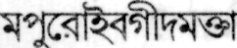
মপুরোইবগীদমক্তা
